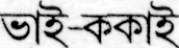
ভাই-ককাই
